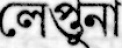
লেপ্তুনা
